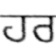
ਹਰ
